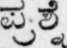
ಪ್ರಶ್ನೆ
